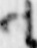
ન
